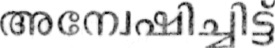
അന്വേഷിച്ചിട്ട്
